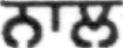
ਨਾਲ
